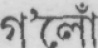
গ'লোঁ
